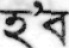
হ'ব
